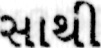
સાથી
